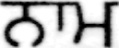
ਨਾਮ
